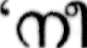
‘നീ
